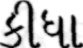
કીધા
